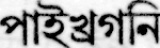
পাইখ্রগনি
